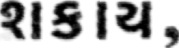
શકાય,
